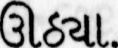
ઊઠ્યા.
